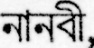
নানবী,
